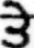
ਤੇ
